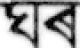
ঘৰ
